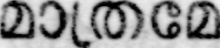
മാത്രമേ
